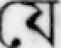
যে
